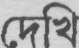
দেখি
